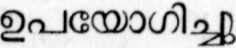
ഉപയോഗിച്ചു
